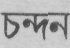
চন্দন
